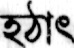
হঠাৎ
